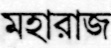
মহারাজ
